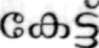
കേട്ട്
